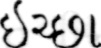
ઈચ્છા
